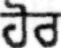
ਹੋਰ
